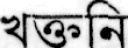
খক্তনি
